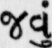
જવું
